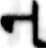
ન
